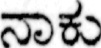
ನಾಕು
